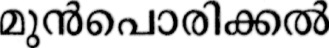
മുന്‍പൊരിക്കല്‍
